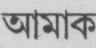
আমাক
